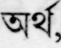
অর্থ,
